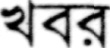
খবর
